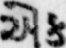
એક
